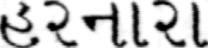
હરનારા
